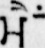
ਮੈਂ
